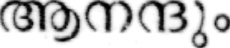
ആനന്ദും
